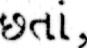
છતાં,
